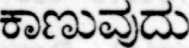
ಕಾಣುವುದು
